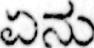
ಏನು
